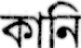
কানি
